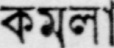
কমলা
